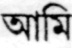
আমি
